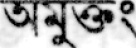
অমুক্তং
